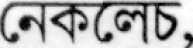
নেকলেচ,
